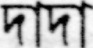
দাদা
